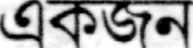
একজন
